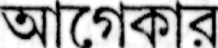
আগেকার
